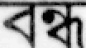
বন্ধ
